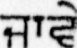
ਜਾਵੇ
